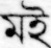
মই
